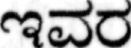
ಇವರ
